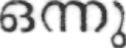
ഒന്നു
